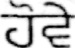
ਹੋਵੇ
